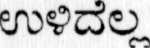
ಉಳಿದೆಲ್ಲ
